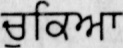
ਚੁਕਿਆ
